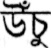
উঁচু
